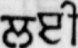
ਲਈ
